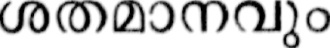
ശതമാനവും
